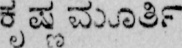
ಕೃಷ್ಣಮೂರ್ತಿ
